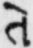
તે
